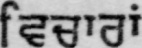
ਵਿਚਾਰਾਂ
